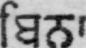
ਬਿਨਾ
